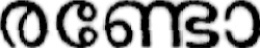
രണ്ടോ
